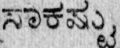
ಸಾಕಷ್ಟು
